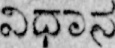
ವಿಧಾನ
